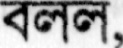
বলল,
